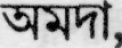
অমদা,
